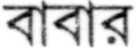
বাবার
